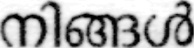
നിങ്ങള്‍
